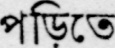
পড়িতে
